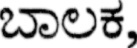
ಬಾಲಕ,
